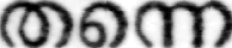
തന്നെ
